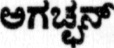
ಅಗಚ್ಛನ್
